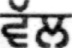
ਵੱਲ
